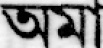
অমা
